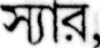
স্যার,
